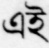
এই
